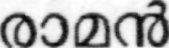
രാമന്‍
